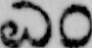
ಎಂ
